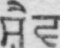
ਸ਼ੈਵ
